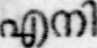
എനി
